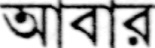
আবার
